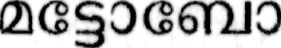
മട്ടോബോ
